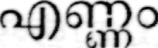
എണ്ണം
